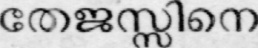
തേജസ്സിനെ
